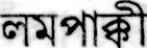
লমপাক্কী
